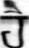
ਹੈ
